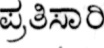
ಪ್ರತಿಸಾರಿ
